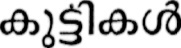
കുട്ടികള്‍
